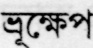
ভ্রূক্ষেপ
